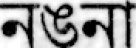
নঙনা
